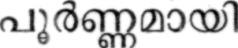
പൂര്‍ണ്ണമായി
